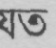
যত
